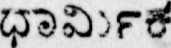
ಧಾರ್ಮಿಕ
